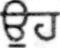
ਉਹ
